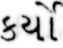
કર્યો
